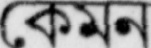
কেমন
